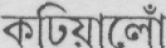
কঢ়িয়ালোঁ
